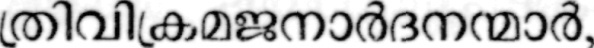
ത്രിവിക്രമജനാര്‍ദനന്മാര്‍,
